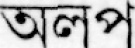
অলপ
